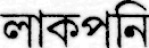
লাকপনি
